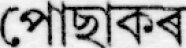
পোছাকৰ
